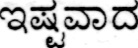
ಇಷ್ಟವಾದ
